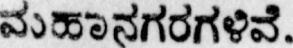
ಮಹಾನಗರಗಳಿವೆ.
